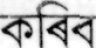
কৰিব
